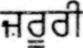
ਜ਼ਰੂਰੀ
